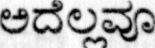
ಅದೆಲ್ಲವೂ
